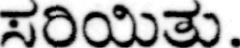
ಸರಿಯಿತು.
